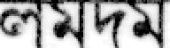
লমদম
